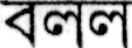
বলল
